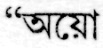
“অয়ো
